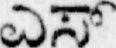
ಎಸ್
